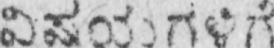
ವಿಷಯಗಳಿಗೆ
